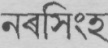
নৰসিংহ
